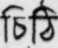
চিঠি
